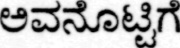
ಅವನೊಟ್ಟಿಗೆ
